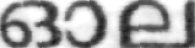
ഓല
